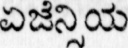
ಏಜೆನ್ಸಿಯ
